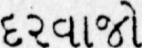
દરવાજો
